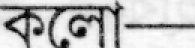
কলো-
